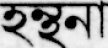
হন্থনা
